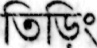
তিড়িং
